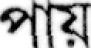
পায়
